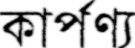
কার্পণ্য
